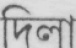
দিলা
